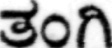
ತಂಗಿ
